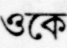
ওকে
